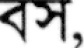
বস,
